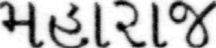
મહારાજ
